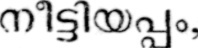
നീട്ടിയപ്പം,
